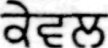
ਕੇਵਲ
